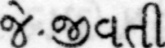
જેજીવતી
